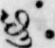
છું.
